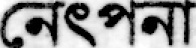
নেৎপনা
